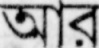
আর
